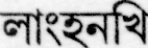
লাংহনখি
